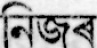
নিজৰ
